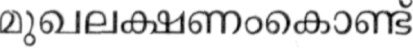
മുഖലക്ഷണംകൊണ്ട്
